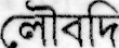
লৌবদি
